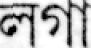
লগা
